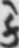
કે
